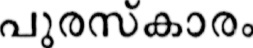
പുരസ്കാരം
